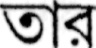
তার
